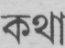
কথা
